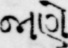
જાણે
